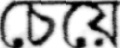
চেয়ে
